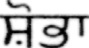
ਸ਼ੋਭਾ
